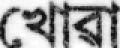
খোৱা
